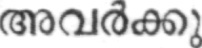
അവര്‍ക്കു
